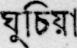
ঘুচিয়া
